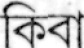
কিবা
